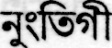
নুংতিগী
